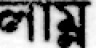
লাম্ন
